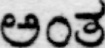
ಅಂತ
